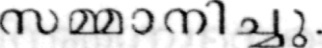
സമ്മാനിച്ചു.
